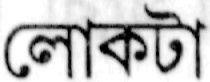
লোকটা
